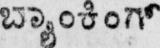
ಬ್ಯಾಂಕಿಂಗ್
